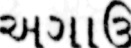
અગાઉ
